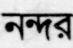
নন্দর
